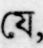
যে,
